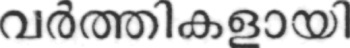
വര്‍ത്തികളായി
